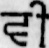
ਵੀ
